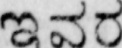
ಇವರ
